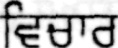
ਵਿਚਾਰ
